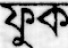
ফুক
